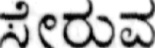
ಸೇರುವ
